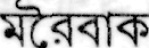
মরৈবাক
